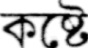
কষ্টে
